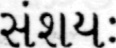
સંશયઃ
